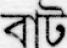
বাট
